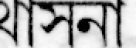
থাসনা
